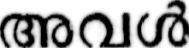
അവള്‍
